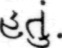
હતું.
